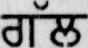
ਗੱਲ
